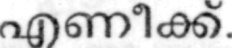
എണീക്ക്.
